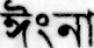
ঈংনা
